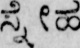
ಸ್ನೇಹ
